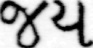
જય
